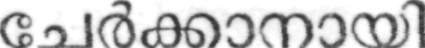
ചേര്‍ക്കാനായി
